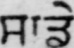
ਸਾਡੇ
